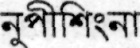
নুপীশিংনা
